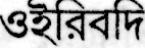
ওইরিবদি
